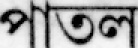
পাতল
